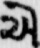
એ
